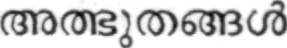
അത്ഭുതങ്ങള്‍
